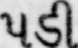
પડી
